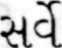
સર્વે
